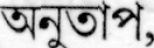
অনুতাপ,
